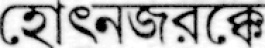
হোৎনজরক্কে
